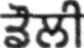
ਡੌਲੀ
